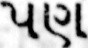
પણ
